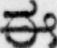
ಈ
